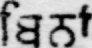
ਬਿਨਾਂ
